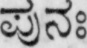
ಪುನಃ
